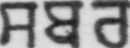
ਸਬਰ
